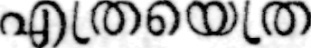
എത്രയെത്ര
